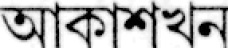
আকাশখন
